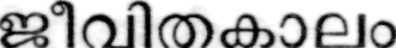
ജീവിതകാലം
